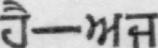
ਹੈ-ਅਜ
